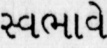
સ્વભાવે
